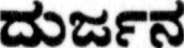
ದುರ್ಜನ
